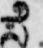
ಸೆ.
